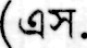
(এস.
